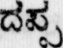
ದಪ್ಪ
